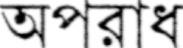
অপরাধ
